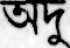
অদু
